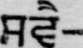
ਸਵੈ-
